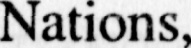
Nations,
